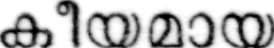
കീയമായ
